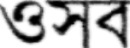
ওসব
